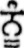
ਨੂੰ
